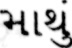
માથું
